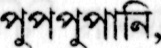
পুপপুপানি,
